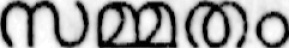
സമ്മതം
